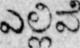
ಎಲ್ಲಿವೆ
